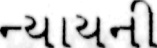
ન્યાયની
